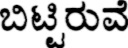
ಬಿಟ್ಟಿರುವೆ
